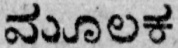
ಮೂಲಕ
